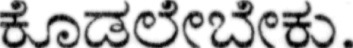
ಕೊಡಲೇಬೇಕು.
